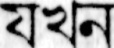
যখন
